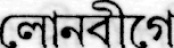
লোনবীগে
